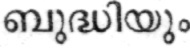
ബുദ്ധിയും
